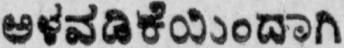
ಅಳವಡಿಕೆಯಿಂದಾಗಿ
